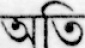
অতি
